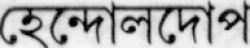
হেন্দোলদোপ
